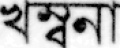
খম্বনা
